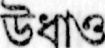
উধাও
